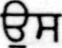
ਉਸ
